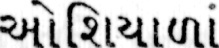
ઓશિયાળાં
